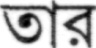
তার
